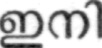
ഇനി
